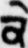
ਕੇ
